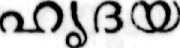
ഹൃദയ
